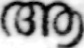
ആ
